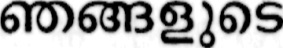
ഞങ്ങളുടെ
